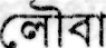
লৌবা
